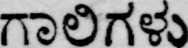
ಗಾಲಿಗಳು
